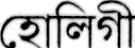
হোলিগী
